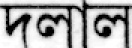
দলাল
